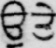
ਉਤੇ
